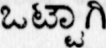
ಒಟ್ಟಾಗಿ
